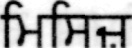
ਮਿਸਿਜ਼
